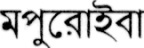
মপুরোইবা
